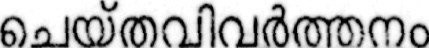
ചെയ്തവിവര്‍ത്തനം
